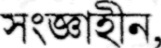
সংজ্ঞাহীন,
